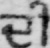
ਦੀ
